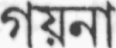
গয়না
